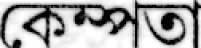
কেম্পতা
